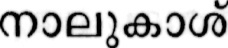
നാലുകാശ്
